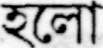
হলো
